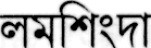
লমশিংদা
